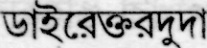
ডাইরেক্তরদুদা
